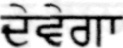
ਦੇਵੇਗਾ
